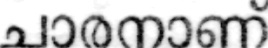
ചാരനാണ്
